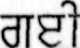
ਗਈ
